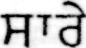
ਸਾਰੇ
